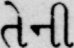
તેની
